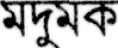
মদুমক
